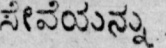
ಸೇವೆಯನ್ನು
